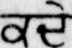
ਕਦੇ
